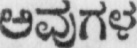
ಅವುಗಳ
